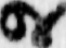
જ
